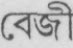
বেজী
